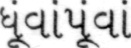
ધૂંવાંપૂંવાં
